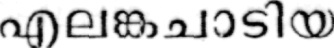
എലങ്കചാടിയ
